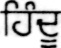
ਹਿੰਦੂ
